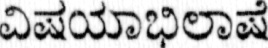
ವಿಷಯಾಭಿಲಾಷೆ
